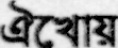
ঐখোয়
